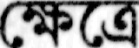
ক্ষেত্রে
